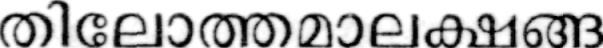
തിലോത്തമാലക്ഷങ്ങ
